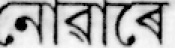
নোৱাৰে
